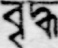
বৃদ্ধ
